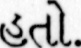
હતો.
